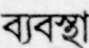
ব্যবস্থা
